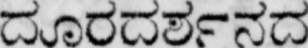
ದೂರದರ್ಶನದ
